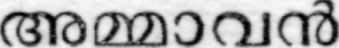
അമ്മാവന്‍
